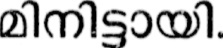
മിനിട്ടായി.
